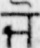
ਜੋ
